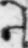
ને
